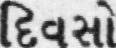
દિવસો
